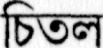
চিতল
